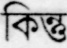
কিন্তু
